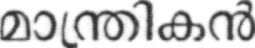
മാന്ത്രികന്‍
